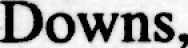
Downs,
